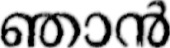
ഞാന്‍
